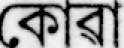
কোৱা
